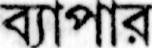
ব্যাপার
